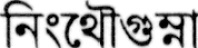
নিংথৌগুম্না
